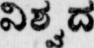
ವಿಶ್ವದ
